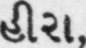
હીરા,
